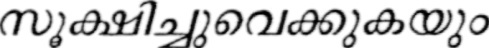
സൂക്ഷിച്ചുവെക്കുകയും
